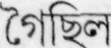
গৈছিল
